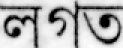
লগত
